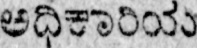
ಅಧಿಕಾರಿಯ
